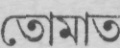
তোমাত
